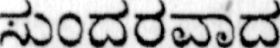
ಸುಂದರವಾದ
